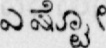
ಎಷ್ಟೋ
